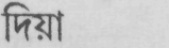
দিয়া
